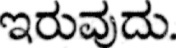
ಇರುವುದು.
